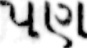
પણ
